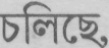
চলিছে,
